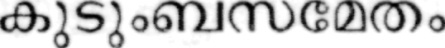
കുടുംബസമേതം
